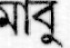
মাবু
